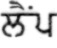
ਲੈਂਪ
